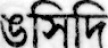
ঙসিদি
